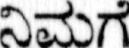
ನಿಮಗೆ
